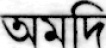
অমদি
